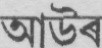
আউৰ
